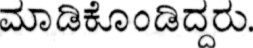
ಮಾಡಿಕೊಂಡಿದ್ದರು.
